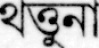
থত্তুনা
